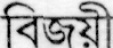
বিজয়ী
